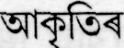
আকৃতিৰ
